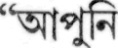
"আপুনি
